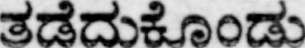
ತಡೆದುಕೊಂಡು
